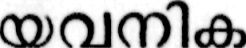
യവനിക
